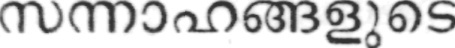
സന്നാഹങ്ങളുടെ
